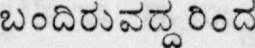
ಬಂದಿರುವದ್ದರಿಂದ
